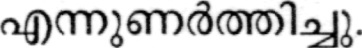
എന്നുണര്‍ത്തിച്ചു.
